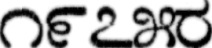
೧೯೭೫ರ
